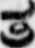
ತ
